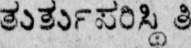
ತುರ್ತುಪರಿಸ್ಥಿತಿ
